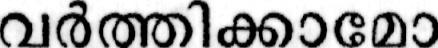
വര്‍ത്തിക്കാമോ
